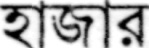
হাজার
